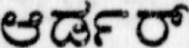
ಆರ್ಡರ್
